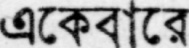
একেবারে
